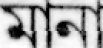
মানা
